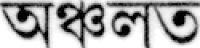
অঞ্চলত
